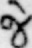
જે
